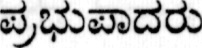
ಪ್ರಭುಪಾದರು
